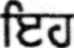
ਇਹ
